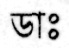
ডাঃ
